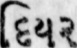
દિયર
